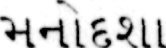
મનોદશા
